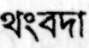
থংবদা
